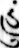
હું
